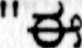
“ಈ
